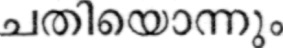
ചതിയൊന്നും
